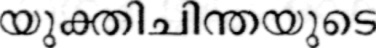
യുക്തിചിന്തയുടെ
